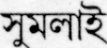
সুমলাই
